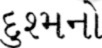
દુશ્મનો
